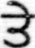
ਤੇ
